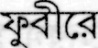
ফুবীরে
